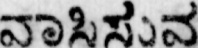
ವಾಸಿಸುವ
